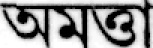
অমত্তা
